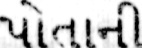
પોતાની
